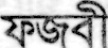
ফজবী
